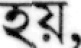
হয়,
